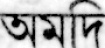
অমদি
